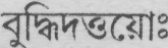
বুদ্ধিদত্তয়োঃ
